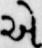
એ
